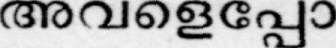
അവളെപ്പോ
